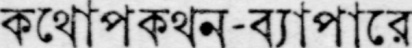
কথোপকথন-ব্যাপারে
